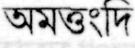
অমত্তংদি
